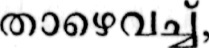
താഴെവച്ച്,
